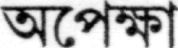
অপেক্ষা
